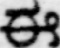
ಈ
